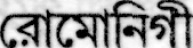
রোমোনিগী
